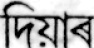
দিয়াৰ
